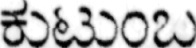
ಕುಟುಂಬ
